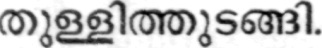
തുള്ളിത്തുടങ്ങി.
